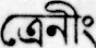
ত্রেনীং
